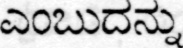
ಎಂಬುದನ್ನು
